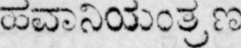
ಹವಾನಿಯಂತ್ರಣ
